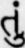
તું
